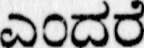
ಎಂದರೆ
